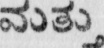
ಮತ್ತು
